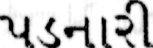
પડનારી
